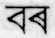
বৰ
